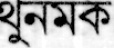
থুনমক
